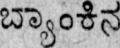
ಬ್ಯಾಂಕಿನ
